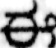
ಈ
